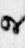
જ
